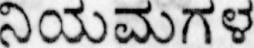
ನಿಯಮಗಳ
